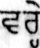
ਵਰ੍ਹੇ
